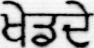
ਖੇਡਦੇ
